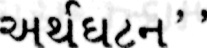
અર્થઘટન"
